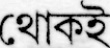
থোকই
